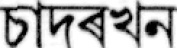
চাদৰখন
